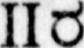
IIರ
